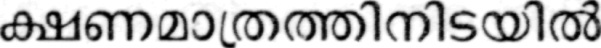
ക്ഷണമാത്രത്തിനിടയില്‍
